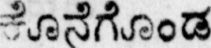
ಕೊನೆಗೊಂಡ
